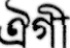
ঐগী
